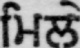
ਮਿਲੇ
